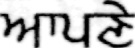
ਆਪਣੇ
